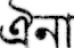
ঐনা
